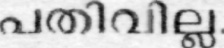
പതിവില്ല.
